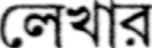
লেখার
